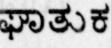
ಘಾತುಕ
